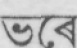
ভৰে
